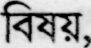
বিষয়,
